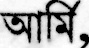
আর্মি,
